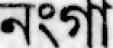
নংগা
